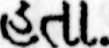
હતા.
